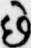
છે
